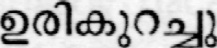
ഉരികുറച്ചു
